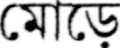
মোড়ে
